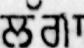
ਲੱਗਾ
